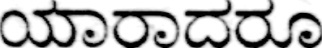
ಯಾರಾದರೂ
